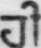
ਹੀ
